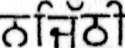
ਨਜਿੱਠੀ
